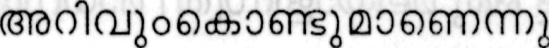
അറിവുംകൊണ്ടുമാണെന്നു
